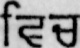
ਵਿਚ
